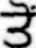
ਤੋਂ
